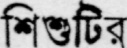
শিশুটির
